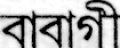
বাবাগী
